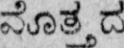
ಮೊತ್ತದ
